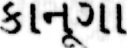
કાનૂગા
